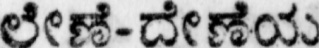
ಲೇಣೆ-ದೇಣೆಯ
